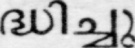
ദ്ധിച്ചു
